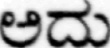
ಅದು
